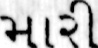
મારી
